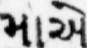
માએ
